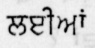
ਲਈਆਂ
